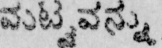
ಮಟ್ವವನ್ನು
